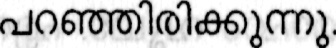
പറഞ്ഞിരിക്കുന്നു.
